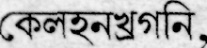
কেলহনখ্রগনি,
